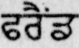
ਫਰੈਂਡ
